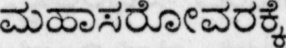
ಮಹಾಸರೋವರಕ್ಕೆ
